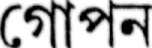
গোপন
